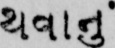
થવાનું
